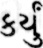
કર્યું
